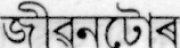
জীৱনটোৰ
